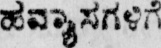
ಹವ್ಯಾಸಗಳಿಗೆ
